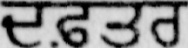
ਦਫ਼ਤਰ
